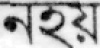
নহয়
